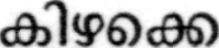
കിഴക്കെ
